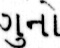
ગુનો
